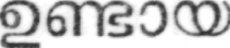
ഉണ്ടായ
